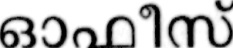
ഓഫീസ്
